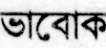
ভাবোক
